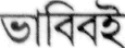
ভাবিবই
